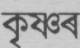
কৃষ্ণৰ
